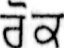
ਰੋਕ
